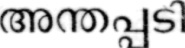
അന്തപ്പടി
